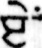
ਏਂ
